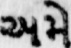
અમે
